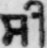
ਸੀ
